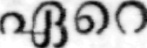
ഏറെ
